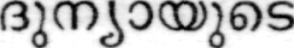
ദുന്യായുടെ
